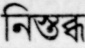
নিস্তব্ধ
